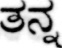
ತನ್ನ
